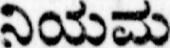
ನಿಯಮ
